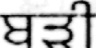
ਬੜੀ
